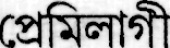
প্রেমিলাগী
